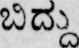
ಬಿದ್ದು
